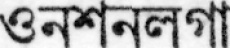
ওনশনলগা
